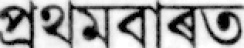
প্রথমবাৰত
